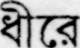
ধীরে
